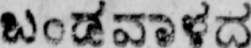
ಬಂಡವಾಳದ
